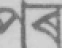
পৰ
